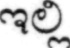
ಇಲ್ಲಿ
